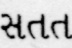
સતત
